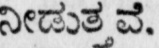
ನೀಡುತ್ತವೆ.
